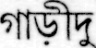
গাড়ীদু
